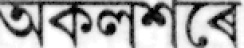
অকলশৰে
